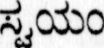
ಸ್ವಯಂ
